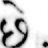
છે.
